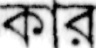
কার
